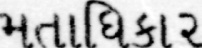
મતાધિકાર
